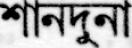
শানদুনা
